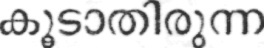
കൂടാതിരുന്ന
